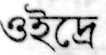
ওইদ্রে
